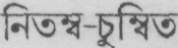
নিতম্ব-চুম্বিত
